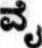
ವೈ
